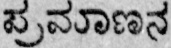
ಪ್ರಮಾಣನ
